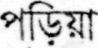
পড়িয়া
